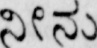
ನೀನು
